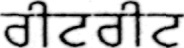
ਰੀਟਰੀਟ
